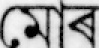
মোৰ
